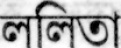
ললিতা
